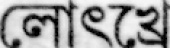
লোৎখ্রে
